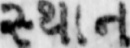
સ્થાન
